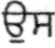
ਉਸ
